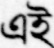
এই
